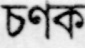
চণক
